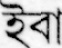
ইবা
